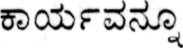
ಕಾರ್ಯವನ್ನೂ
